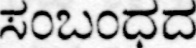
ಸಂಬಂಧದ
